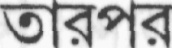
তারপর
